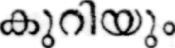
കുറിയും
